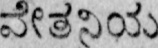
ವೇತನಿಯ
